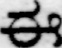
ಈ
